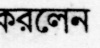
করলেন
